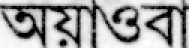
অয়াওবা
